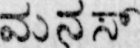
ಮನಸ್
